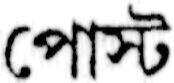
পোস্ট
